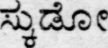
ಸ್ಕುಡೋ
